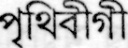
পৃথিবীগী
